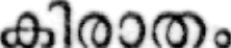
കിരാതം
